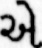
એ
